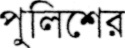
পুলিশের
